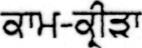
ਕਾਮ-ਕ੍ਰੀੜਾ
